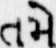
તમે
